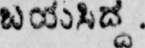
ಬಯಸಿದ್ದ.
